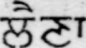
ਲੈਣਾ
